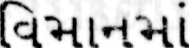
વિમાનમાં
